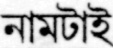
নামটাই
